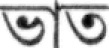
ভাত
